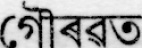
গৌৰৱত
